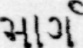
માર્ગ
